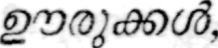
ഊരുക്കള്‍,
